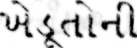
ખેડૂતોની
